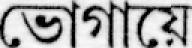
ভোগায়ে
